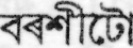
বৰশীটো
